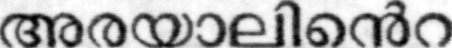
അരയാലിന്റെ
